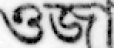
ওজা
